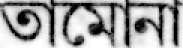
তামোনা
